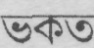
ভকত
